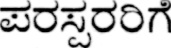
ಪರಸ್ಪರರಿಗೆ
